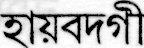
হায়বদগী
